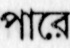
পারে
